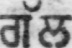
ਗੱਲ
